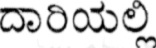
ದಾರಿಯಲ್ಲಿ
